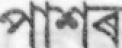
পাশৰ
